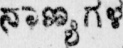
ನಾಣ್ಯಗಳ
